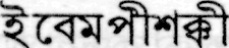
ইবেমপীশক্কী
